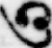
ও
